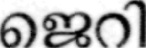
ജെറി
